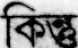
কিন্তু
